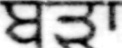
ਬੜਾ
